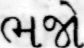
ભજો
